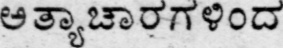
ಅತ್ಯಾಚಾರಗಳಿಂದ
